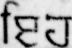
ਇਹ
